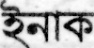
ইনাক
